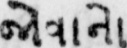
જોવાનો
